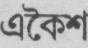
একৈশ
